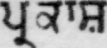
ਪ੍ਰਕਾਸ਼
